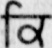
ਕਿ
